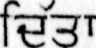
ਦਿੱਤਾ
